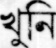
খুনি
